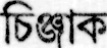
চিঞ্জাক
